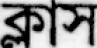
ক্লাস
